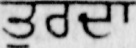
ਤੁਰਦਾ
